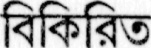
বিকিরিত
